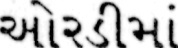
ઓરડીમાં
